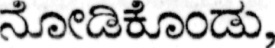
ನೋಡಿಕೊಂಡು,
